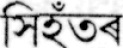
সিহঁতৰ
